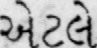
એટલે
